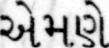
એમણે
